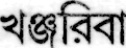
খঞ্জরিবা
